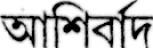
আশির্বাদ
